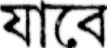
যাবে
